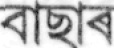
বাছাৰ
